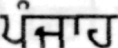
ਪੰਜਾਹ
